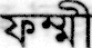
ফম্মী
